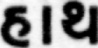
હાથ
